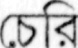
চেরি
